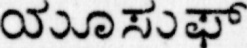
ಯೂಸುಫ್
